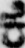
ಕೆ
